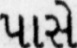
પાસે
